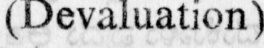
(Devaluation)
